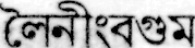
লৈনীংবগুম
